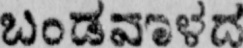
ಬಂಡವಾಳದ
